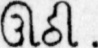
ઊઠી.
